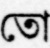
তো
